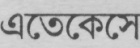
এতেকেসে
